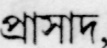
প্রাসাদ,
